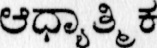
ಆಧ್ಯಾತ್ಮಿಕ
